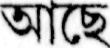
আছে
